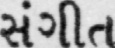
સંગીત
